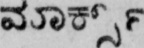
ಮಾರ್ಕ್ಸ್
